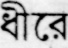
ধীরে
